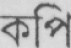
কপি
